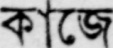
কাজে
